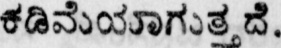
ಕಡಿಮೆಯಾಗುತ್ತದೆ.
